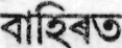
বাহিৰত
